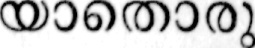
യാതൊരു
